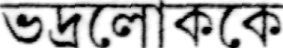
ভদ্রলোককে
